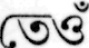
তেওঁ
